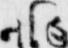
નહિ
